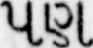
પણ
